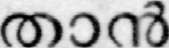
താന്‍
